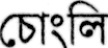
চোংলি
